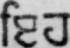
ਇਹ
